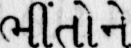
ભીંતોને
